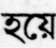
হয়ে
